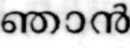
ഞാന്‍
